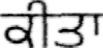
ਕੀਤਾ
